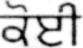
ਕੋਈ
